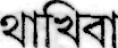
থাখিবা
